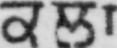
ਕਲਾ
